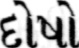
દોષો
